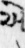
એ
